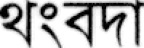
থংবদা
